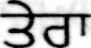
ਤੇਰਾ
